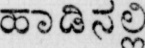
ಹಾಡಿನಲ್ಲಿ
